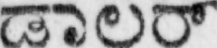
ಡಾಲರ್
